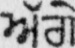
ਅੱਗੇ
